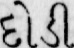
દોડી
